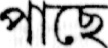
পাছে
